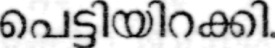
പെട്ടിയിറക്കി.
